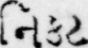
નિકટ
